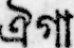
ঐগা
